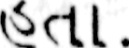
હતા.
